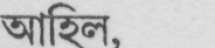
আহিল,
